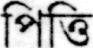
পিত্তি
